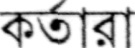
কর্তারা
